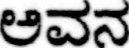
ಅವನ
